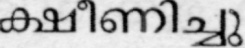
ക്ഷീണിച്ചു
